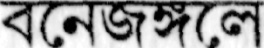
বনেজঙ্গলে
